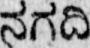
ನಗದಿ
